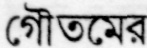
গৌতমের
